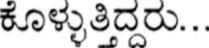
ಕೊಳ್ಳುತ್ತಿದ್ದರು...
